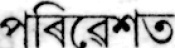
পৰিৱেশত
